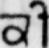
ਕੀ
